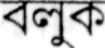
বলুক
